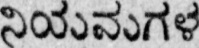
ನಿಯಮಗಳ
